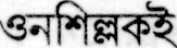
ওনশিল্লকই
